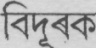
বিদূৰক
